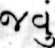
જવું
